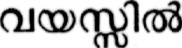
വയസ്സില്‍
